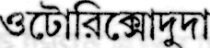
ওটোরিক্সোদুদা
